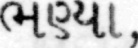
ભણ્યા,
